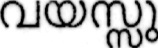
വയസ്സു
